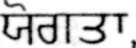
ਯੋਗਤਾ,
